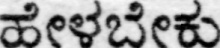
ಹೇಳಬೇಕು
